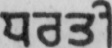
ਧਰਤੀ
